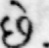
છે.
